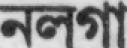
নলগা
